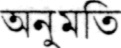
অনুমতি
